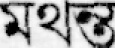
মথন্ত
